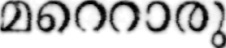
മറെറാരു
